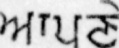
ਆਪਣੇ
